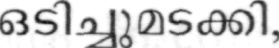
ഒടിച്ചുമടക്കി,
